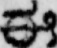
ಈ
